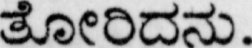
ತೋರಿದನು.
